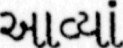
આવ્યાં
